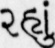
રહ્યું
